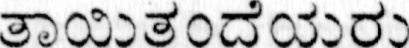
ತಾಯಿತಂದೆಯರು
